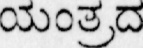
ಯಂತ್ರದ
